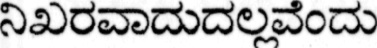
ನಿಖರವಾದುದಲ್ಲವೆಂದು
